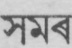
সমৰ
